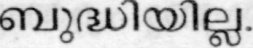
ബുദ്ധിയില്ല.
